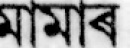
মামাৰ
